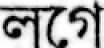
লগে
